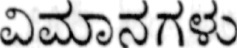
ವಿಮಾನಗಳು
